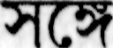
সঙ্গে
